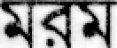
মরম
